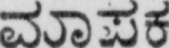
ಮಾಪಕ
